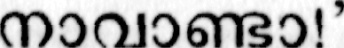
നാവാണ്ടാ!’
